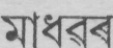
মাধৱৰ
